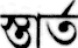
স্তর্ত
